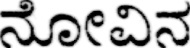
ನೋವಿನ
